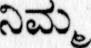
ನಿಮ್ಮ
